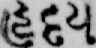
હદય
